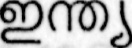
ഇന്ത്യ
